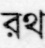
রথ
